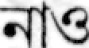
নাও
